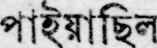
পাইয়াছিল
